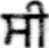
ਸੀ
